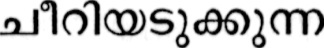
ചീറിയടുക്കുന്ന
